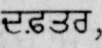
ਦਫ਼ਤਰ,
